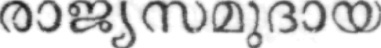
രാജ്യസമുദായ
